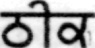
ਠੀਕ
